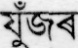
যুঁজৰ
